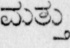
ಮತ್ತು
